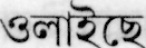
ওলাইছে
